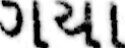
ગયા
